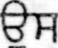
ਉਸ
